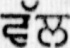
ਵੱਲ
